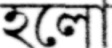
হলো
